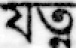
যত্ন
